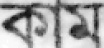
কাম
